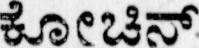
ಕೋಚಿನ್
